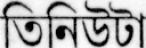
তিনিউটা
